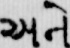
અને
